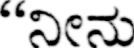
"ನೀನು
